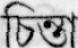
চিন্তা
